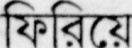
ফিরিয়ে
